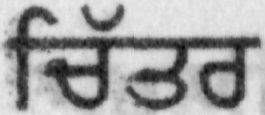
ਚਿੱਤਰ
